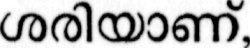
ശരിയാണ്,
